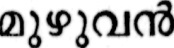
മുഴുവന്‍
